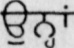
ਉਨ੍ਹਾਂ
